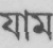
যাম
